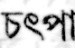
চৎপা
